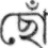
ছোঁ
